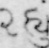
રહ્યું
